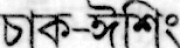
চাক-ঈশিং
